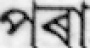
পৰা
